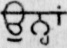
ਉਨ੍ਹਾਂ
